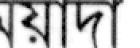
ময়াদা
